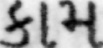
કામ
